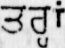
ਤਰ੍ਹਾਂ
